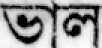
ভাল
